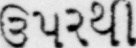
ઉપરથી
